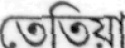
তেতিয়া
